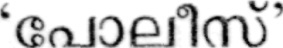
‘പോലീസ്’
